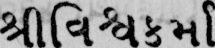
શ્રીવિશ્વકર્મા
